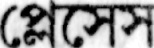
প্লেসেস
